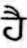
ਹੈ
